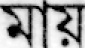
মায়
